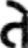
તે
